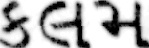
કલમ
